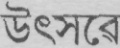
উৎসৱে
